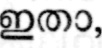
ഇതാ,
